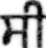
ਸੀ
